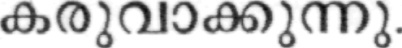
കരുവാക്കുന്നു.
